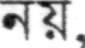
নয়,
